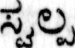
ಸ್ವಲ್ಪ
